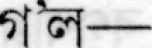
গ'ল-
